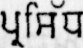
ਪ੍ਰਸਿੱਧ
